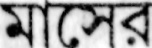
মাসের
